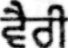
ਵੈਰੀ
